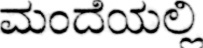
ಮಂದೆಯಲ್ಲಿ
